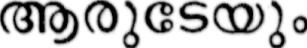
ആരുടേയും
